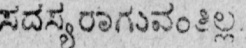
ಸದಸ್ಯರಾಗುವಂತಿಲ್ಲ
